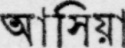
আসিয়া
